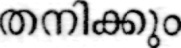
തനിക്കും
